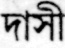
দাসী
